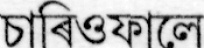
চাৰিওফালে
